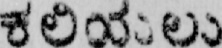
ಕಲಿಯಲು
